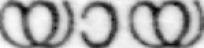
യായ
